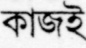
কাজই
